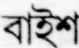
বাইশ
